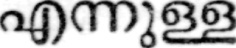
എന്നുള്ള
